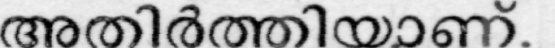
അതിര്‍ത്തിയാണ്.
